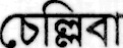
চেল্লিবা
